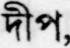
দীপ,
